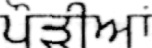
ਪੌੜੀਆਂ
